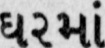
ઘરમાં
